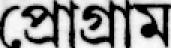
প্রোগ্রাম
